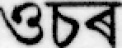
ওচৰ
